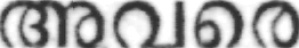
അവരെ
